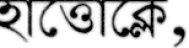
হাত্তোক্লে,
